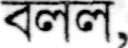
বলল,
